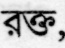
রক্ত,
